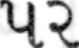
પર
